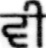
ਵੀ
